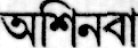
অশিনবা
